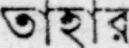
তাহার
